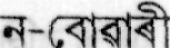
ন-বোৱাৰী
